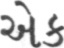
એક
